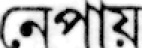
নেপায়
